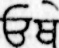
ਓਥੇ
